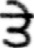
ਤੇ
